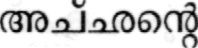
അച്ഛന്റെ
